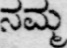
ನಮ್ಮ
